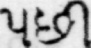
પછી
